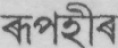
ৰূপহীৰ
